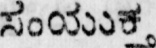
ಸಂಯುಕ್ತ
